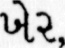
ખેર,
